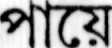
পায়ে
